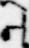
ને
